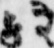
કરે
